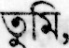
তুমি,
